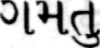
ગમતું
